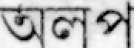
অলপ
